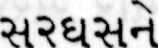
સરઘસને
